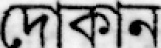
দোকান
